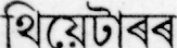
থিয়েটাৰৰ
